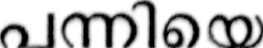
പന്നിയെ
